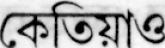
কেতিয়াও
